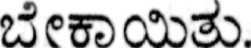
ಬೇಕಾಯಿತು.
